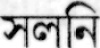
সলনি
